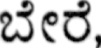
ಬೇರೆ,
